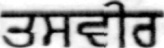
ਤਸਵੀਰ
